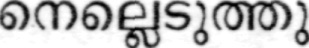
നെല്ലെടുത്തു
